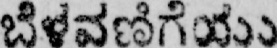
ಬೆಳವಣಿಗೆಯು
